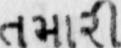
તમારી
